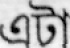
এটা
